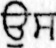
ਉਸ
